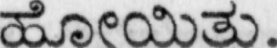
ಹೋಯಿತು.
